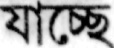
যাচ্ছে
